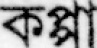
কপ্পা
